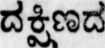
ದಕ್ಷಿಣದ
